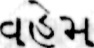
વહેમ
